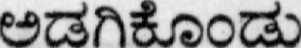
ಅಡಗಿಕೊಂಡು
